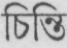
চিন্তি
